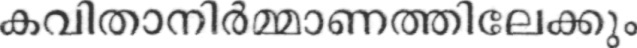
കവിതാനിര്‍മ്മാണത്തിലേക്കും
